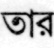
তার
